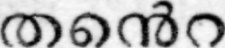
തന്റെ
